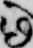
છે
